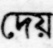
দেয়
